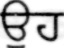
ਉਹ
